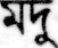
মদু
